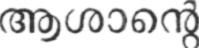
ആശാന്റെ
